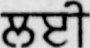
ਲਈ
